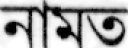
নামত
